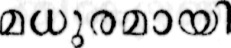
മധുരമായി
